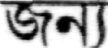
জন্য
